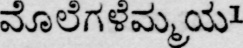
ಮೊಲೆಗಳೆಮ್ಮಯ1
